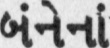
બંનેનાં
